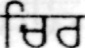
ਚਿਰ
